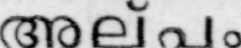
അല്പം
